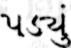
પડ્યું
